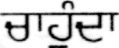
ਚਾਹੁੰਦਾ
